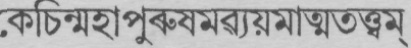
কেচিন্মহাপুৰুষমৱ্যয়মাত্মতত্ত্বম্
